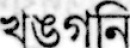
খঙগনি
